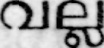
വല്ല
